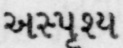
અસ્પૃશ્ય
